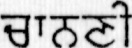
ਚਾਨਣੀ
